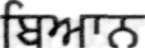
ਬਿਆਨ
